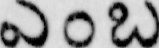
ಎಂಬ
